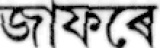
জাফৰে
